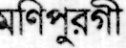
মণিপুরগী
